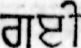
ਗਈ
